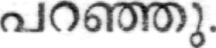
പറഞ്ഞു.
